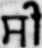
ਸੀ
